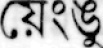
য়েংঙু
